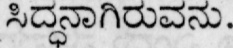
ಸಿದ್ಧನಾಗಿರುವನು.
